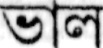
ভাল
